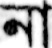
না
